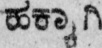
ಹಕ್ಕಾಗಿ
